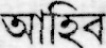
আহিব
